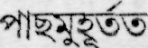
পাছমুহূর্তত
